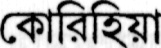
কোরিহিয়া
